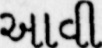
આવી
